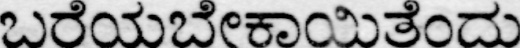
ಬರೆಯಬೇಕಾಯಿತೆಂದು
